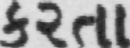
કરતા
